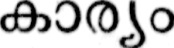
കാര്യം
